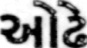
ઓઢે
